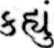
કહ્યું
